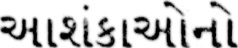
આશંકાઓનો
